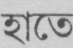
হাতে
